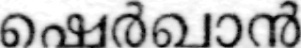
ഷെര്‍ഖാന്‍
